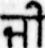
ਜੀ
